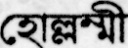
হোল্লম্মী
